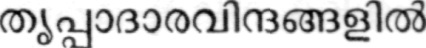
തൃപ്പാദാരവിന്ദങ്ങളില്‍
